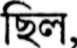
ছিল,
